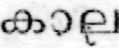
കാല
